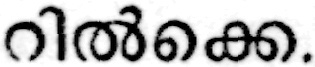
റില്‍ക്കെ.
